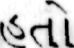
હતો
